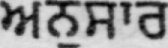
ਅਨੁਸਾਰ
